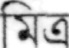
মিত্র
